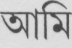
আমি
